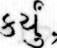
કર્યું,
